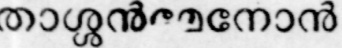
താശ്ശന്‍മേനോന്‍
